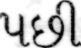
પછી
